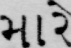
મારે
